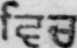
ਵਿਚ
